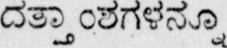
ದತ್ತಾಂಶಗಳನ್ನೂ
